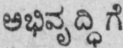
ಅಭಿವೃದ್ಧಿಗೆ
